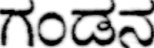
ಗಂಡನ
